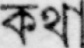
কথা
